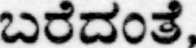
ಬರೆದಂತೆ,
